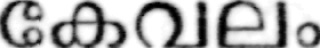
കേവലം
